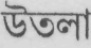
উতলা
